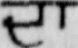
ਦਾ
